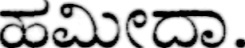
ಹಮೀದಾ.
